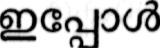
ഇപ്പോള്‍
